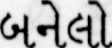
બનેલો
